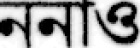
ননাও
